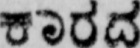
ಕಾರದ
